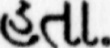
હતા.
